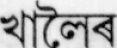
খালৈৰ
